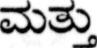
ಮತ್ತು
